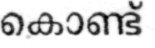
കൊണ്ട്
